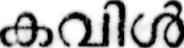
കവിള്‍
